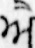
ਐ
